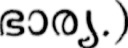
ഭാര്യ.)
